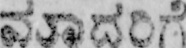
ಮಾದರಿಗೆ
